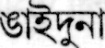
ঙাইদুনা
